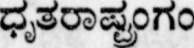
ಧೃತರಾಷ್ಟ್ರಂಗಂ
